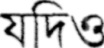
যদিও
